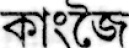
কাংজৈ
